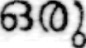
ഒരു
